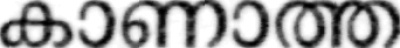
കാണാത്ത
